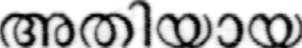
അതിയായ
